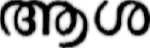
ആശ
